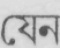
যেন
